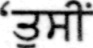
'ਤੁਸੀਂ
